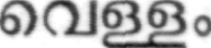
വെള്ളം
